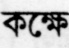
কক্ষে
